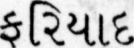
ફરિયાદ
